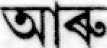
আৰু
